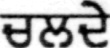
ਚਲਦੇ
